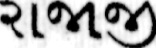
રાજાજી
